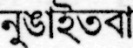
নুংঙাইতবা
